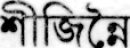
শীজিন্নৈ
